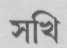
সখি
